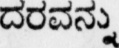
ದರವನ್ನು
